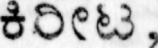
ಕಿರೀಟ,
